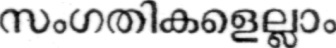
സംഗതികളെല്ലാം
